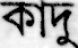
কাদু
